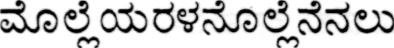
ಮೊಲ್ಲೆಯರಳನೊಲ್ಲೆನೆನಲು
